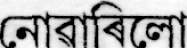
নোৱাৰিলো
